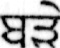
ਬੜੇ
